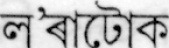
ল'ৰাটোক
